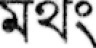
মথং
